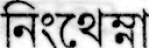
নিংথেম্না
